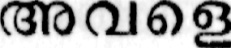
അവളെ
